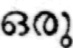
ഒരു
